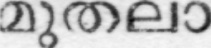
മുതലാ
